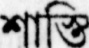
শাস্তি
